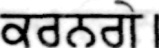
ਕਰਨਗੇ।
